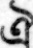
ঐ
